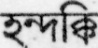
হন্দক্কি
